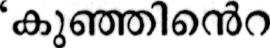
'കുഞ്ഞിൻറ
